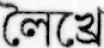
লৈখ্রে
